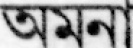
অমনা
